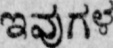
ಇವುಗಳ
